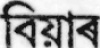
বিয়াৰ
